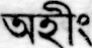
অহীং
